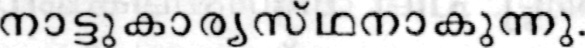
നാട്ടുകാര്യസ്ഥനാകുന്നു.
